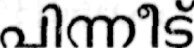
പിന്നീട്
